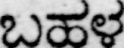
ಬಹಳ
